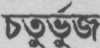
চতুৰ্ভুজ
